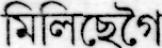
মিলিছেগৈ
